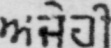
ਅਜੇਹੀ
